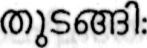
തുടങ്ങി:
